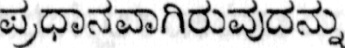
ಪ್ರಧಾನವಾಗಿರುವುದನ್ನು
